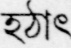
হঠাত্
